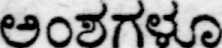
ಅಂಶಗಳೂ
